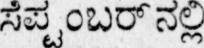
ಸೆಪ್ಟಂಬರ್‌ನಲ್ಲಿ
